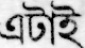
এটাই
